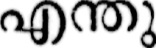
എന്തു
